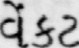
વેંકટ
